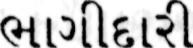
ભાગીદારી
